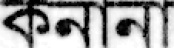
কনানা
